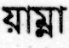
য়াম্না
